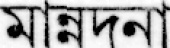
মান্নদনা
